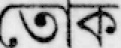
তোক
